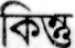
কিন্তু
